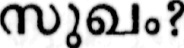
സുഖം?
